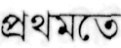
প্রথমতে
